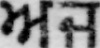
ਅਜ
